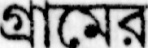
গ্রামের
